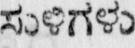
ಸುಳಿಗಳು
